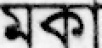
মকা
